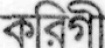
করিগী
